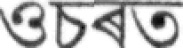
ওচৰত
